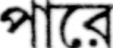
পারে
